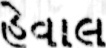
હેવાલ
